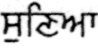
ਸੁਣਿਆ
